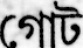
গোট
